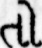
તો
